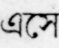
এসে
